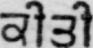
ਕੀਤੀ
